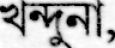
খন্দুনা,
